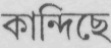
কান্দিছে
